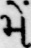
મેં
